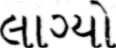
લાગ્યો
